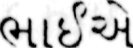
ભાઈએ
